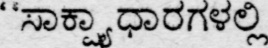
“ಸಾಕ್ಷ್ಯಾಧಾರಗಳಲ್ಲಿ
